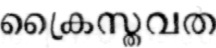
ക്രൈസ്തവത
